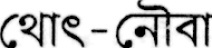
থোৎ-নৌবা
